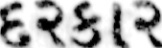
દરકાર
